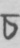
চ
